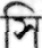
সি
